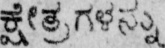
ಕ್ಷೇತ್ರಗಳನ್ನು
